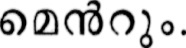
മെന്റും.
